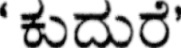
'ಕುದುರೆ'
